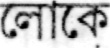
লোকে
